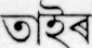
তাইৰ
